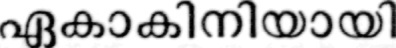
ഏകാകിനിയായി
